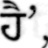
ਹੈ',
